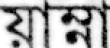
য়াম্না
